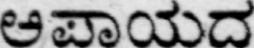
ಅಪಾಯದ
